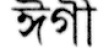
ঈগী
